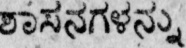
ಶಾಸನಗಳನ್ನು
